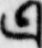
এ
